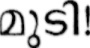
മുടി!
